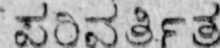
ಪರಿವರ್ತಿತ
